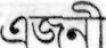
এজনী
